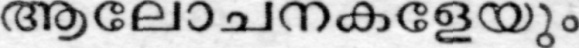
ആലോചനകളേയും
